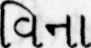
વિના
